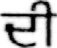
ਦੀ
